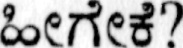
ಹೀಗೇಕೆ?
